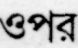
ওপর
